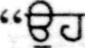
''ਉਹ
